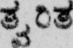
ತ್ವರಿತ
